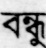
বন্ধু
